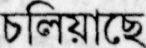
চলিয়াছে
